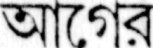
আগের
